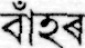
বাঁহৰ
